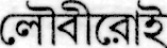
লৌবীরোই
